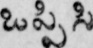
ಒಪ್ಪಿಸಿ
